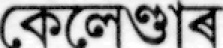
কেলেণ্ডাৰ
